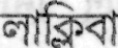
লাক্লিবা
